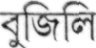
বুজিলি
